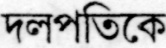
দলপতিকে
